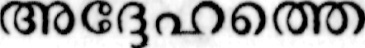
അദ്ദേഹത്തെ
